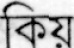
কিয়
